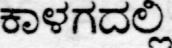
ಕಾಳಗದಲ್ಲಿ
